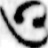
ও
